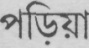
পড়িয়া
